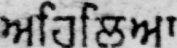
ਅਹਿਲਿਆ
